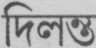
দিলন্ত
